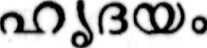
ഹൃദയം
